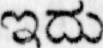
ಇದು
